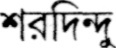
শরদিন্দু
